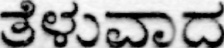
ತೆಳುವಾದ
